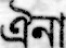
ঐনা
